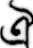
ঐ
